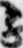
કે
